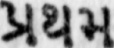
પ્રથમ
